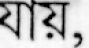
যায়,
